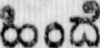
ಹಿಂದೆ
